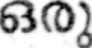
ഒരു
